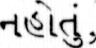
નહોતું,
